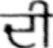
ਦੀ
